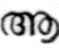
ആ
